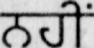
ਨਹੀਂ
